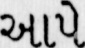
આપે
